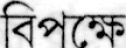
বিপক্ষে
